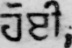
ਹੋਈ,
